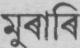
মুৰাৰি
